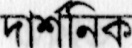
দার্শনিক
